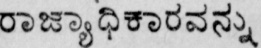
ರಾಜ್ಯಾಧಿಕಾರವನ್ನು
